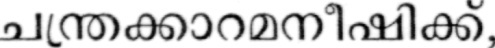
ചന്ത്രക്കാറമനീഷിക്ക്,
